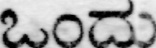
ಒಂದು
